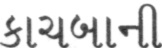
કાચબાની
